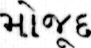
મોજૂદ
